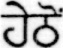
ਹੇਠੋਂ
